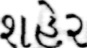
શહેર
